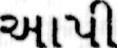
આપી
